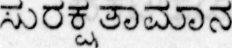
ಸುರಕ್ಷತಾಮಾನ
